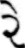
રે
